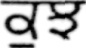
ਕੁਝ
